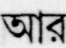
আর
